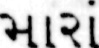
મારાં
